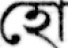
হো
